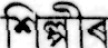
শিল্পীৰ
